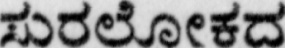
ಸುರಲೋಕದ
